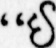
"ઈ
